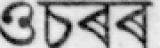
ওচৰৰ
